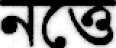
নত্তে
